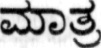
ಮಾತ್ರ
